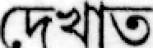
দেখাত
